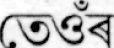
তেওঁৰ
